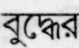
বুদ্ধের
